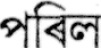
পৰিল
